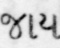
જાય
